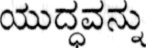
ಯುದ್ಧವನ್ನು
